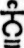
ਨੂੰ
